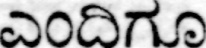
ಎಂದಿಗೂ
